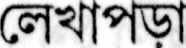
লেখাপড়া
